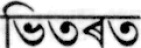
ভিতৰত
